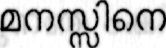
മനസ്സിനെ
